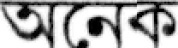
অনেক
